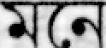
মনে
